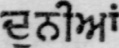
ਦੁਨੀਆਂ
